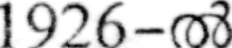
1926-ല്‍
